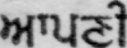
ਆਪਣੀ
